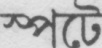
স্পটে
